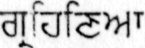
ਗ੍ਰਹਿਣਿਆ
